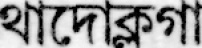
থাদোক্লগা
